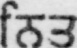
ਨਿਤ
